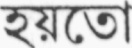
হয়তো
